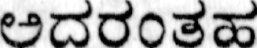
ಅದರಂತಹ
